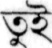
তুই
